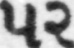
પર
